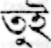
তুই
